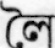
লৈ
